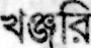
খঞ্জরি
